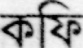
কফি
